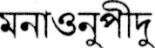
মনাওনুপীদু
